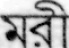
মরী
